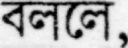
বললে,
